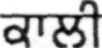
ਕਾਲੀ
